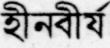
হীনবীর্য
